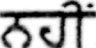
ਨਹੀਂ
